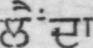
ਲੈਂਦਾ
